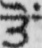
ਤੋਂ
